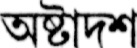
অষ্টাদশ
